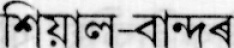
শিয়াল-বান্দৰ
